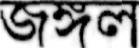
জঙ্গল
